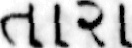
તારા
